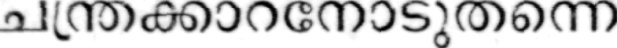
ചന്ത്രക്കാറനോടുതന്നെ
